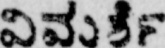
ವಿಮರ್ಶೆ
